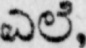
ಎಲೆ,
